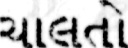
ચાલતો
